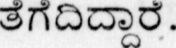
ತೆಗೆದಿದ್ದಾರೆ.
